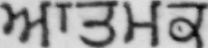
ਆਤਮਕ
